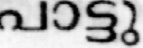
പാട്ടു
